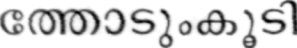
ത്തോടുംകൂടി
